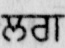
ਲਗ
